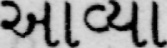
આવ્યા
